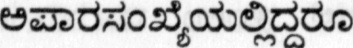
ಅಪಾರಸಂಖ್ಯೆಯಲ್ಲಿದ್ದರೂ
